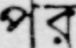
পর
